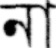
না
